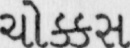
ચોક્કસ
